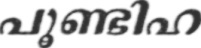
പൂണ്ടിഹ
